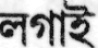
লগাই
